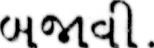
બજાવી.
